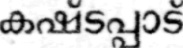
കഷ്ടപ്പാട്
